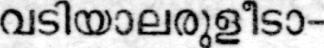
വടിയാലരുളീടാ-
